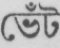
ভেঁট
